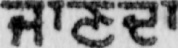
ਜਾਣਦਾ
